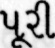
પૂરી
